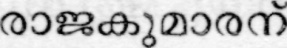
രാജകുമാരന്
